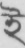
ই
